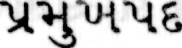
પ્રમુખપદ
